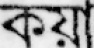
কয়া
